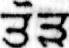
ਤੋੜ
